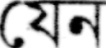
যেন
